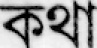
কথা
